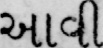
આવી
